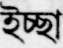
ইচ্ছা
